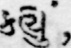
કહ્યું,
